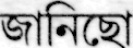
জানিছো
